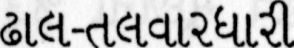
ઢાલ-તલવારધારી
